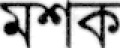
মশক
